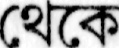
থেকে
